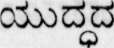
ಯುದ್ಧದ
